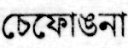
চেফোঙনা
